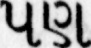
પણ
